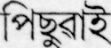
পিছুৱাই
